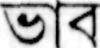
ভাব
